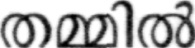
തമ്മില്‍
